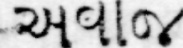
અવાજ
